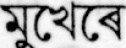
মুখেৰে
